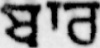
ਬਾਰ
